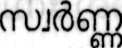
സ്വര്‍ണ്ണ
